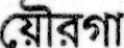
য়ৌরগা
